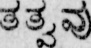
ತತ್ವವು
